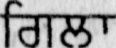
ਗਿਲਾ
